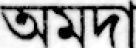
অমদা
